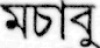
মচাবু
